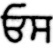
ਓਸ
